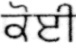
ਕੋਈ
